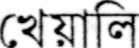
খেয়ালি
